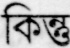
কিন্তু
